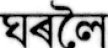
ঘৰলৈ
